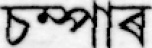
চম্পাৰ
